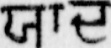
ਯਾਦ
